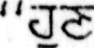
''ਹੁਣ
